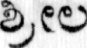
ಶ್ರೀಲ
